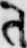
તે
